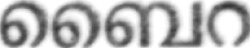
ബൈറ
